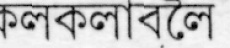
কলকলাবলৈ
